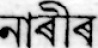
নাৰীৰ
